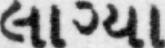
લાગ્યા
